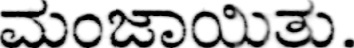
ಮಂಜಾಯಿತು.
